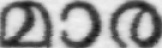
മാര
